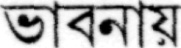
ভাবনায়
